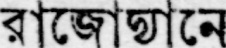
রাজোদ্যানে
